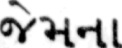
જેમના
